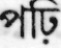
পঢ়ি
